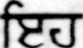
ਇਹ
